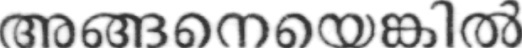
അങ്ങനെയെങ്കില്‍
